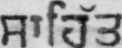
ਸਾਹਿੱਤ
